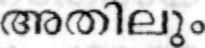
അതിലും
